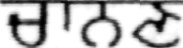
ਚਾਨਣ
